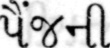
પૈંજની
